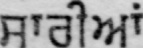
ਸਾਰੀਆਂ
